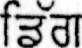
ਡਿੱਗ
